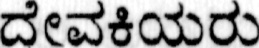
ದೇವಕಿಯರು
